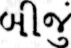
બીજું
